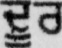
ਦੂਰ
